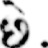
છે.
